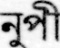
নুপী
